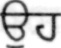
ਉਹ
